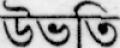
উভতি
